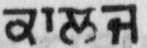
ਕਾਲਜ
